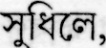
সুধিলে,
